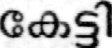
കേട്ടി
